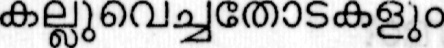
കല്ലുവെച്ചതോടകളും
